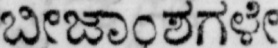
ಬೀಜಾಂಶಗಳೇ
